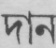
দান
